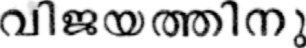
വിജയത്തിനു
